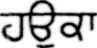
ਹਉਕਾ
